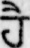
ਹੈ
